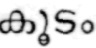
കൂടം
